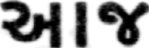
આજ
